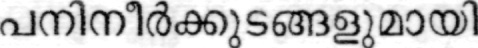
പനിനീര്‍ക്കുടങ്ങളുമായി
